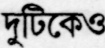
দুটিকেও
